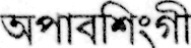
অপাবশিংগী
